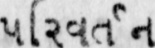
પરિવર્તન
